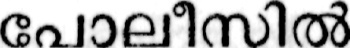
പോലീസില്‍
